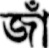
জাঁ
